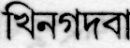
খিনগদবা
